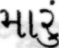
મારું
